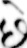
છે
